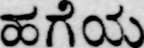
ಹಗೆಯ
